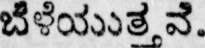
ಬೆಳೆಯುತ್ತವೆ.
